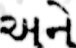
અને
